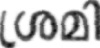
ശ്രമി
